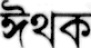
ঈথক
